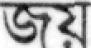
জয়
